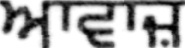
ਆਵਾਜ਼
